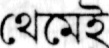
থেমেই
